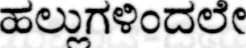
ಹಲ್ಲುಗಳಿಂದಲೇ
